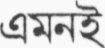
এমনই
